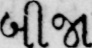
બીજા
